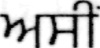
ਅਸੀਂ
